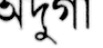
অদুগা
